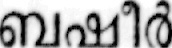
ബഷീര്‍
